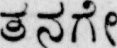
ತನಗೇ
